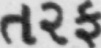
તરફ
